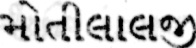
મોતીલાલજી
